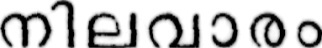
നിലവാരം
